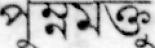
পূম্নমক্তু
